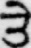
ਤੇ
